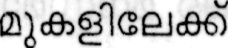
മുകളിലേക്ക്
